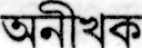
অনীখক
